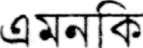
এমনকি
